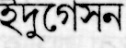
ইদুগেসন
